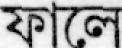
ফালে
